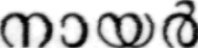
നായര്‍
